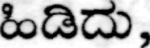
ಹಿಡಿದು,
